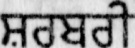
ਸ਼ਰਬਰੀ
